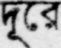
দূরে
